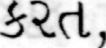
કરત,
